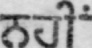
ਨਹੀਂ
